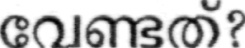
വേണ്ടത്?
